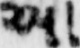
આ
